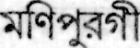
মণিপুরগী
